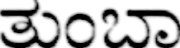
ತುಂಬಾ
